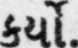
કર્યો.
